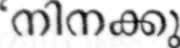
'നിനക്കു
